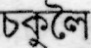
চকুলৈ
